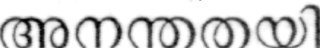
അനന്തതയി
